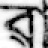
ৱা
